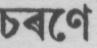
চৰণে
